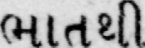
ભાતથી
